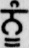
ਨੂੰ
